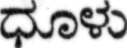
ಧೂಳು
